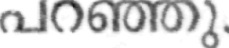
പറഞ്ഞു.
